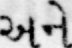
અને
